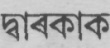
দ্বাৰকাক
